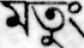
মতুং
